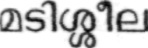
മടിശ്ശീല
